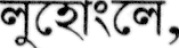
লুহোংলে,
